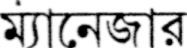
ম্যানেজার
